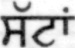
ਸੱਟਾਂ
